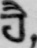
ਹੈ,
